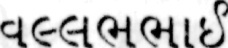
વલ્લભભાઈ
